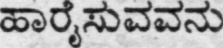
ಹಾರೈಸುವವನು
